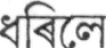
ধৰিলে
